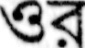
ওর
